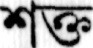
শক্ত
